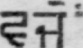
ਵਜੋਂ
